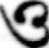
ও
